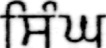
ਸਿੰਘ
